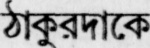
ঠাকুরদাকে
